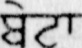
ਬੇਟਾ
